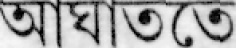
আঘাততে
